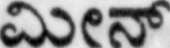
ಮೀನ್
